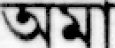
অমা
